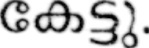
കേട്ടു.
